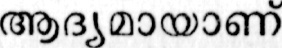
ആദ്യമായാണ്
